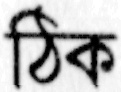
ঠিক
